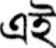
এই
